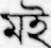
মই
